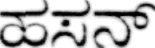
ಹಸನ್
